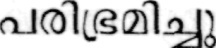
പരിഭ്രമിച്ചു
